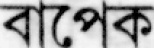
বাপেক
